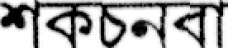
শকচনবা
